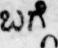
ಬಗ್ಗೆ
